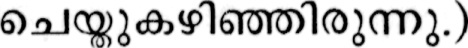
ചെയ്തുകഴിഞ്ഞിരുന്നു.)
